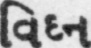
વિઘ્ન
